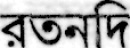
রতনদি
